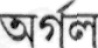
অর্গল
